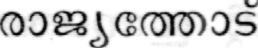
രാജ്യത്തോട്
